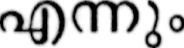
എന്നും
